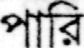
পারি
